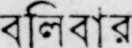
বলিবার
